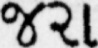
જરા
